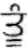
ਤੂੰ
